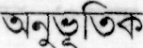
অনুভূতিক
